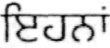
ਇਹਨਾਂ
